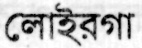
লোইরগা
